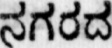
ನಗರದ
